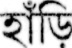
হাঁড়ি
